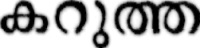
കറുത്ത
